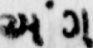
અંગ
